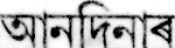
আনদিনাৰ
